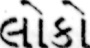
લોકો
